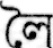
লৈ
